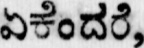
ಏಕೆಂದರೆ,
